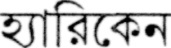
হ্যারিকেন
